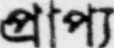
প্রাপ্য
